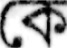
কে
